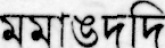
মমাঙদদি
